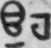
ਉਹ
